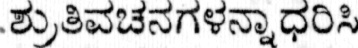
ಶ್ರುತಿವಚನಗಳನ್ನಾಧರಿಸಿ
